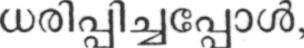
ധരിപ്പിച്ചപ്പോള്‍,
